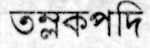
তম্লকপদি
